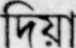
দিয়া
